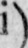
i)
